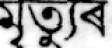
মৃত্যুৰ
